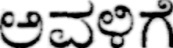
ಅವಳಿಗೆ
